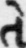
તે
